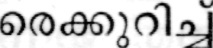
രെക്കുറിച്ച്
